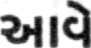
આવે
